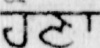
ਹੋਣਾ
